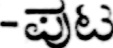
-ಪುಟ
